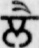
ਲੈ
